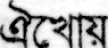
ঐখোয়
